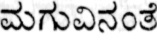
ಮಗುವಿನಂತೆ
